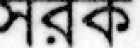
সরক
